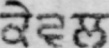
ਕੇਵਲ
